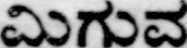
ಮಿಗುವ
